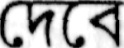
দেবে
